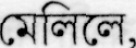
মেলিলে,
